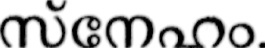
സ്നേഹം.
